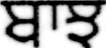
ਬਾਝ
